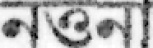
নত্তনা
